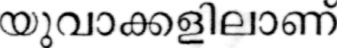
യുവാക്കളിലാണ്
